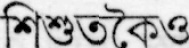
শিশুতকৈও
